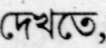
দেখতে,
